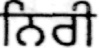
ਨਿਰੀ
